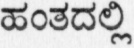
ಹಂತದಲ್ಲಿ
